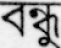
বন্ধু
